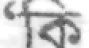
'কি
